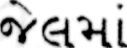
જેલમાં
